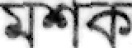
মশক
